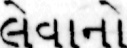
લેવાનો
